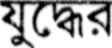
যুদ্ধের
